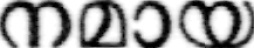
നമായ
